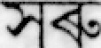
সৰু
